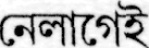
নেলাগেই
